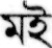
মই
